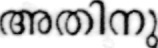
അതിനു
